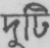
দুটি
